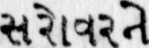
સરોવરને
